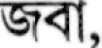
জবা,
